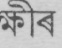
ক্ষীৰ
